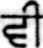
ਵੀ
